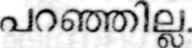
പറഞ്ഞില്ല.
